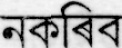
নকৰিব
